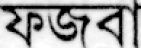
ফজবা
